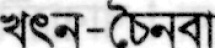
খৎন-চৈনবা
